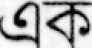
এক
